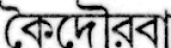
কৈদৌরবা
